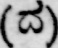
(ದ)
